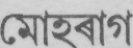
মোহৰাগ
